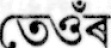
তেওঁৰ
